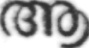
ആ
